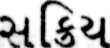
સક્રિય
